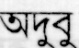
অদুবু
